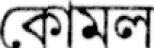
কোমল
